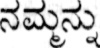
ನಮ್ಮನ್ನು
